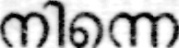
നിന്നെ
